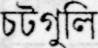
চটগুলি
